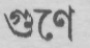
গুণে
